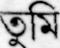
তুমি
